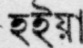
হইয়া
